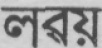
লৱয়
